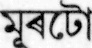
মূৰটো
